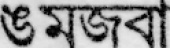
ঙমজবা
